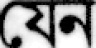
যেন
